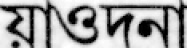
য়াওদনা
